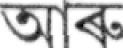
আৰু
